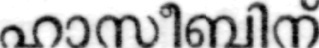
ഹാസീബിന്
